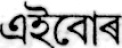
এইবোৰ
